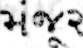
મંજૂર
